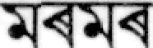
মৰমৰ
